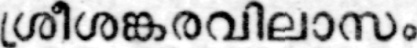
ശ്രീശങ്കരവിലാസം
